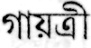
গায়ত্রী
